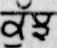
ਕੁੱਝ
